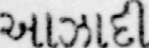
આઝાદી
